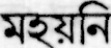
মহয়নি
